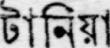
টানিয়া
